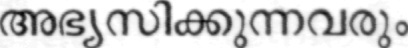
അഭ്യസിക്കുന്നവരും
